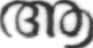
ആ
